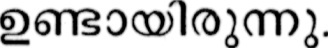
ഉണ്ടായിരുന്നു.
